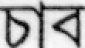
চাব
